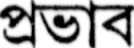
প্রভাব
